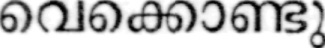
വെക്കൊണ്ടു
